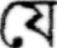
যে
